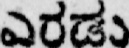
ಎರಡು
